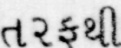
તરફથી
